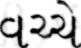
વચ્ચે
